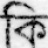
কি
